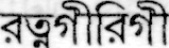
রত্নগীরিগী
